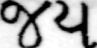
જય
